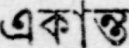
একান্ত
